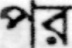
পর
